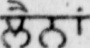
ਲੈਨਾਂ
